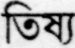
তিষ্য
